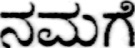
ನಮಗೆ
